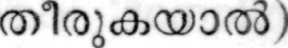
തീരുകയാല്‍)
